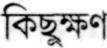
কিছুক্ষণ
